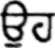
ਉਹ
